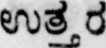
ಉತ್ತರ
